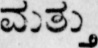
ಮತ್ತು
